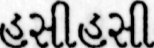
હસીહસી
